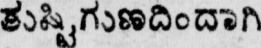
ತುಷ್ಟಿಗುಣದಿಂದಾಗಿ
